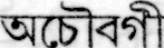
অচৌবগী
